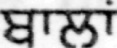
ਬਾਲਾਂ
